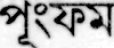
পুংফম
